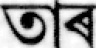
তাৰ
